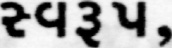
સ્વરૂપ,
